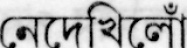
নেদেখিলোঁ
